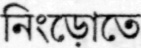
নিংড়োতে
